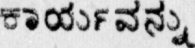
ಕಾರ್ಯವನ್ನು
